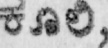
ಕೂಲಿ,
